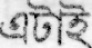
এটাই
